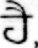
ਹੈ,
